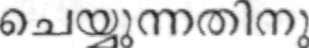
ചെയ്യുന്നതിനു
